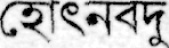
হোৎনবদু
